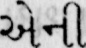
એની
